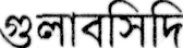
গুলাবসিদি
